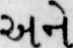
અને
